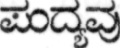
ಪಂದ್ಯವು
